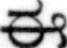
ಈ
